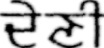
ਦੇਣੀ
